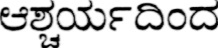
ಆಶ್ಚರ್ಯದಿಂದ
